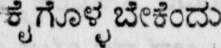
ಕೈಗೊಳ್ಳಬೇಕೆಂದು
